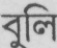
বুলি
